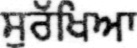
ਸੁਰੱਖਿਆ
